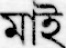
মাই
